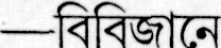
-বিবিজানে
